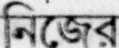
নিজের
